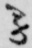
કે
